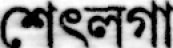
শেৎলগা
